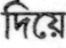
দিয়ে
